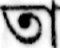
তা
